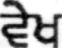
ਵੇਖ
